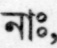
নাঃ,
